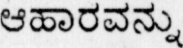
ಆಹಾರವನ್ನು
